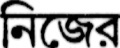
নিজের
